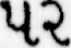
પર
